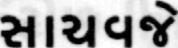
સાચવજે
